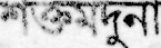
শক্তমদুনা
